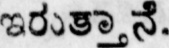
ಇರುತ್ತಾನೆ.
